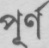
পূৰ্ণ
